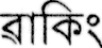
ৱাকিং
